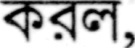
করল,
